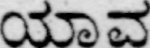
ಯಾವ
